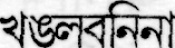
খঙলবনিনা
